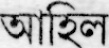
আহিল
